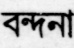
বন্দনা
